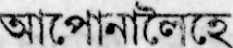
আপোনালৈহে
